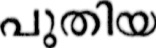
പുതിയ
